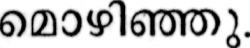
മൊഴിഞ്ഞു.
